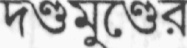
দণ্ডমুণ্ডের
